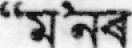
"ম'নৰ
